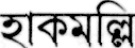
হাকমল্লি
